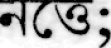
নত্তে;
